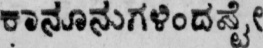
ಕಾನೂನುಗಳಿಂದಷ್ಟೇ
